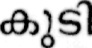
കുടി
